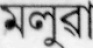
মলুৱা
